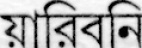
য়ারিবনি
